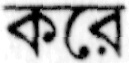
করে
